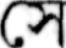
সে
